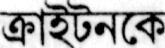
ক্রাইটনকে
